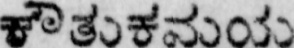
ಕೌತುಕಮಯ
